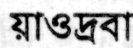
য়াওদ্রবা
